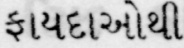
ફાયદાઓથી
